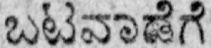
ಬಟವಾಡೆಗೆ
